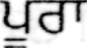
ਪੂਰਾ
